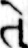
તે
